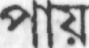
পায়
